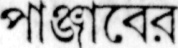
পাঞ্জাবের
